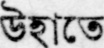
উহাতে
